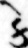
કે
